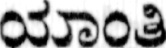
ಯಾಂತಿ
